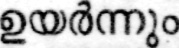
ഉയര്‍ന്നും
